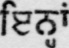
ਇਨ੍ਹਾਂ
